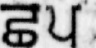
ਛਪ
